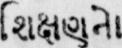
શિક્ષણનો
